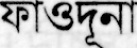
ফাওদূনা
